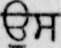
ਉਸ
